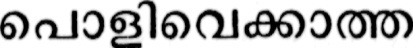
പൊളിവെക്കാത്ത
